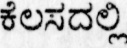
ಕೆಲಸದಲ್ಲಿ
